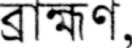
ব্রাহ্মণ,
